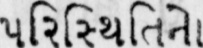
પરિસ્થિતિનો
